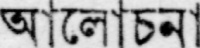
আলোচনা
